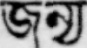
জন্য
